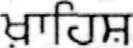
ਖ਼ਾਹਿਸ਼
